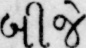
બીજે
